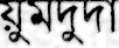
য়ুমদুদা
